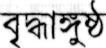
বৃদ্ধাঙ্গুষ্ঠ
